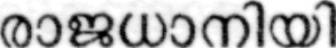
രാജധാനിയി
